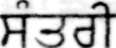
ਸੰਤਰੀ
